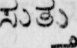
ಸುತ್ತು
